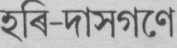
হৰি-দাসগণে
